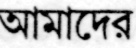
আমাদের
